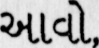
આવો,
